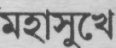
মহাসুখে
